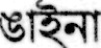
ঙাইনা
